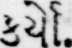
કર્યો.
